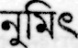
নুমিৎ
